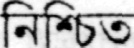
নিশ্চিত
